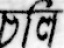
চলি
